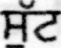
ਸੁੱਟ
